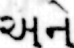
અને
